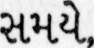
સમયે,
